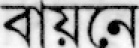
বায়নে
